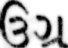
ઉગ્ર
